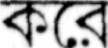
করে
